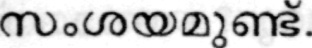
സംശയമുണ്ട്.
